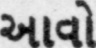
આવો
